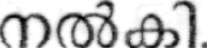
നല്‍കി.
